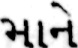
માને
